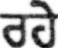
ਰਹੇ
